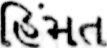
હિંમત
